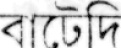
বাটেদি
